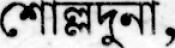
শোল্লদুনা,
